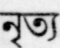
নৃত্য
